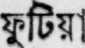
ফুটিয়া
